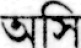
অসি
